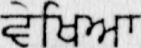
ਵੇਖਿਆ
